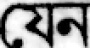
যেন
